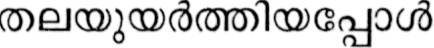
തലയുയര്‍ത്തിയപ്പോള്‍
